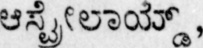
ಆಸ್ಟ್ರೇಲಾಯ್ಡ್,
